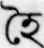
হৈ
